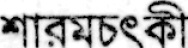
শারমচৎকী
